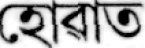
হোৱাত
